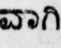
ವಾಗಿ
